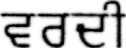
ਵਰਦੀ
